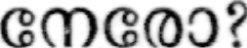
നേരോ?
